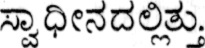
ಸ್ವಾಧೀನದಲ್ಲಿತ್ತು.
